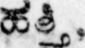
ಹತ್ತಿ,
